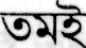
তমই
